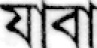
যাবা
